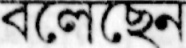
বলেছেন
